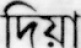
দিয়া
